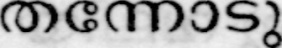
തന്നോടു
